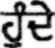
ਹੁੰਦੇ
